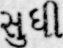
સુધી
